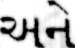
અને
